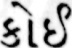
કોઈ
